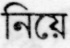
নিয়ে
